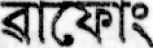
ৱাফোং
